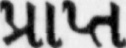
પ્રાપ્ત
